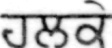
ਹਲਕੇ
